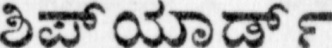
ಶಿಪ್‌ಯಾರ್ಡ್
